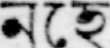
নহে
